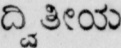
ದ್ವಿತೀಯ
